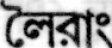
লৈরাং
